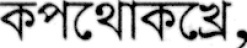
কপথোকখ্রে,
